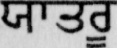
ਯਾਤਰੂ
